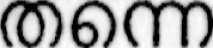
തന്നെ
